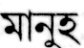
মানুহ
